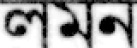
লমন
